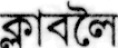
ক্লাবলৈ
